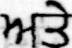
ਅਤੇ
